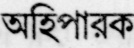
অহিপারক
